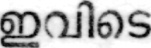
ഇവിടെ
